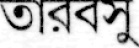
তারবসু
